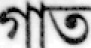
গাত
